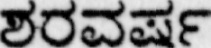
ಶರವರ್ಷ
